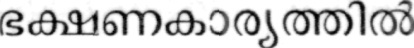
ഭക്ഷണകാര്യത്തില്‍
